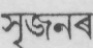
সৃজনৰ
